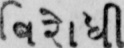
વિરોધી
